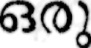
ഒരു
